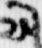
એ
